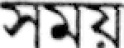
সময়
